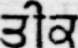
ਤੀਕ
